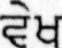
ਵੇਖ
